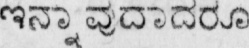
ಇನ್ನಾವುದಾದರೂ
